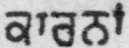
ਕਾਰਨਾਂ
